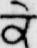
ਕੇ
